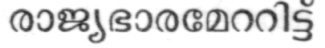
രാജ്യഭാരമേററിട്ട്
